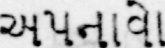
અપનાવો
